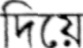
দিয়ে
